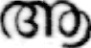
ആ
